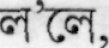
ল'লে,
